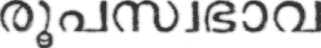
രൂപസ്വഭാവ
